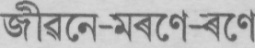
জীৱনে-মৰণে-ৰণে
